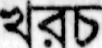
খরচ
